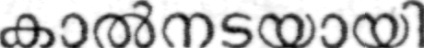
കാല്‍നടയായി
